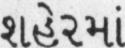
શહેરમાં
